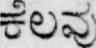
ಕೆಲವು
